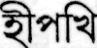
হীপখি
